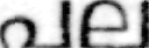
പല
